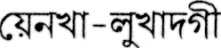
য়েনখা-লুখাদগী
